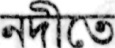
নদীতে
